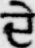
ਦੇ
